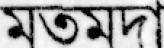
মতমদা
